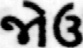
જોઉ
